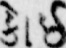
કોઈ
